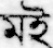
মই
